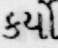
કર્યો
